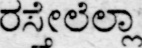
ರಸ್ತೇಲೆಲ್ಲಾ
